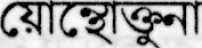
য়োন্থোক্তুনা
